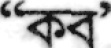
"কব'
